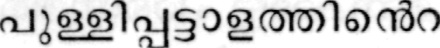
പുള്ളിപ്പട്ടാളത്തിന്റെ
